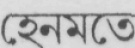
হেনমতে
